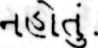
નહોતું.
